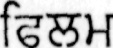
ਫਿਲਮ
